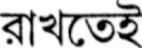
রাখতেই
